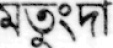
মতুংদা
